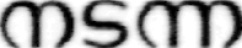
നടന്ന
